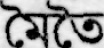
মৈতৈ
